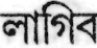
লাগিব
